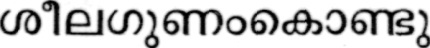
ശീലഗുണംകൊണ്ടു
